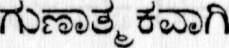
ಗುಣಾತ್ಮಕವಾಗಿ
